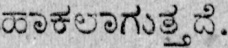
ಹಾಕಲಾಗುತ್ತದೆ.
